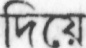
দিয়ে
